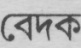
বেদক
